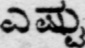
ಎಷ್ಟು
